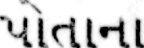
પોતાના
